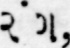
રંગ,
